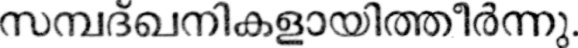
സമ്പദ്ഖനികളായിത്തീര്‍ന്നു.
